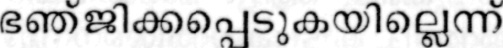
ഭഞ്ജിക്കപ്പെടുകയില്ലെന്ന്
